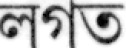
লগত
